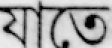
যাতে
